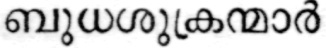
ബുധശുക്രന്മാര്‍
